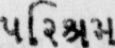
પરિશ્રમ
